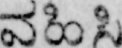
ವಹಿಸಿ
